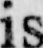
is
